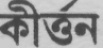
কীৰ্ত্তন
